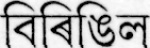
বিৰিঙিল
